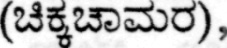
(ಚಿಕ್ಕಚಾಮರ),
